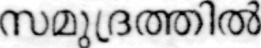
സമുദ്രത്തില്‍
